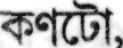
কণটো,
